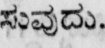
ಸುವುದು.
